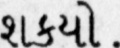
શક્યો.
